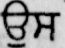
ਉਸ
